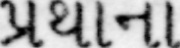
પ્રથાના
